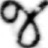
જ
